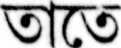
তাতে
